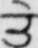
ਤੇ
